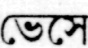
ভেসে
